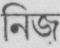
নিজ
